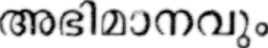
അഭിമാനവും
